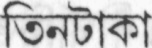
তিনটাকা
